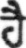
ਹੈ
